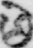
છે
